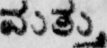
ಮತ್ತು
